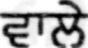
ਵਾਲੇ
